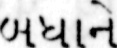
બધાને
